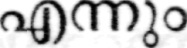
എന്നും
